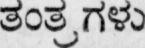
ತಂತ್ರಗಳು
